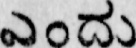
ಎಂದು
